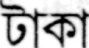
টাকা
